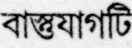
বাস্তুযাগটি
